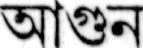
আগুন
